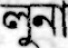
লুনা
